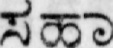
ಸಹಾ
